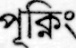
পূক্নিং
